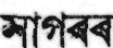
সাগৰৰ
